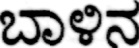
ಬಾಳಿನ
